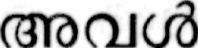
അവള്‍
